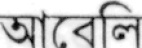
আবেলি
